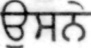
ਉਸਨੇ
